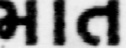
માત
